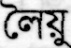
লৈয়ু
